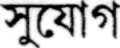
সুযোগ
